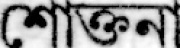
শোক্তনা
